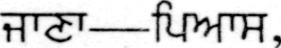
ਜਾਣਾ-ਪਿਆਸ,
